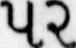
પર
